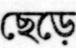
ছেড়ে
